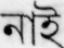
নাই
